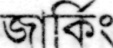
জার্কিং
